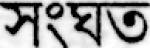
সংঘত
